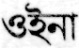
ওইনা
